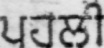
ਪਹਲੀ
